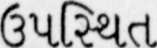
ઉપસ્થિત
